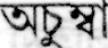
অচুম্বা
